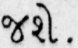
જશે.
